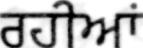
ਰਹੀਆਂ
